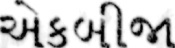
એકબીજા
